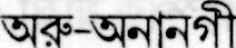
অরু-অনানগী
